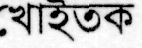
খোইতক
